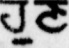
ਹੁਣ
